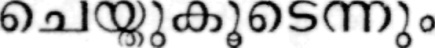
ചെയ്തുകൂടെന്നും
